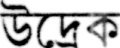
উদ্রেক
